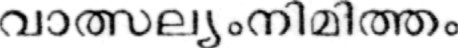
വാത്സല്യംനിമിത്തം
